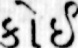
કોઇ
